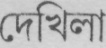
দেখিলা
